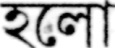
হলো
